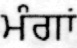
ਮੰਗਾਂ
